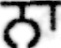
ਨਾ
